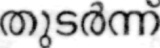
തുടര്‍ന്ന്
